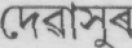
দেৱাসুৰ
